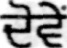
ਦੋਵੇਂ
